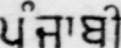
ਪੰਜਾਬੀ
